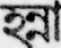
হন্না
